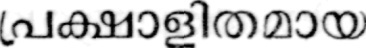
പ്രക്ഷാളിതമായ
